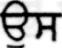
ਉਸ
